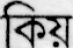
কিয়
